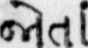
જોતાં
